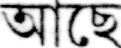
আছে
